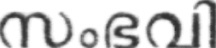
സംഭവി
